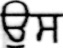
ਉਸ
